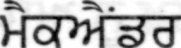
ਮੈਕਐਂਡਰ
